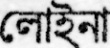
লোইনা
